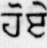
ਹੋਏ
